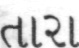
તારા
